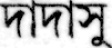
দাদাসু
